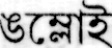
ঙম্লোই
